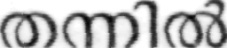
തന്നില്‍
